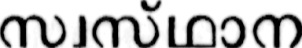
സ്വസ്ഥാന
